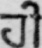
ਹੀ
